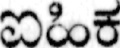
ಐಹಿಕ
